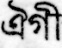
ঐগী
